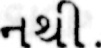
નથી.
